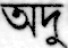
অদু
